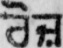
ਰੋਜ਼
